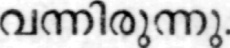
വന്നിരുന്നു.
